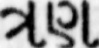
ત્રણ
